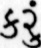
કરું
